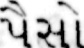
પૈસો
